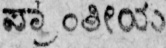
ಪ್ರಾಂತೀಯ
